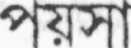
পয়সা
